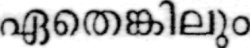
ഏതെങ്കിലും
